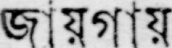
জায়গায়
